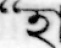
“হা
